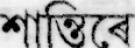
শান্তিৰে
